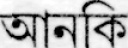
আনকি
